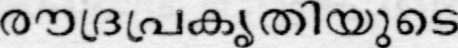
രൌദ്രപ്രകൃതിയുടെ
